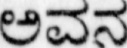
ಅವನ
